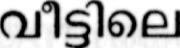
വീട്ടിലെ
